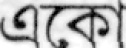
একো
